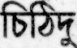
চিঠিদু
